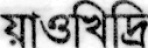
য়াওখিদ্রি
